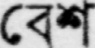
বেশ
